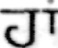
ਹਾਂ
